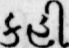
કહી
